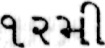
૧૨મી
